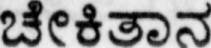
ಚೇಕಿತಾನ
